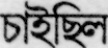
চাইছিল
